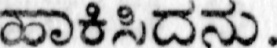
ಹಾಕಿಸಿದನು.
